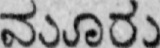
ಮೂರು
